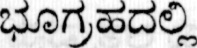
ಭೂಗ್ರಹದಲ್ಲಿ
